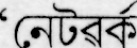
'নেটৱর্ক
